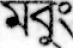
মবুং
